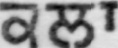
ਕਲਾ
